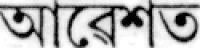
আৱেশত
